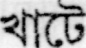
খাটে
